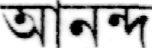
আনন্দ
